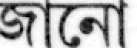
জানো
